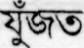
যুঁজত
